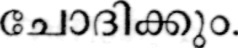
ചോദിക്കും.
